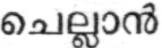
ചെല്ലാന്‍
